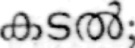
കടല്‍;
